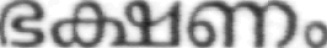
ഭക്ഷണം
